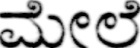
ಮೇಲೆ
